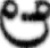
ಆ
